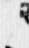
જે
